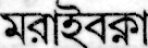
মরাইবক্না
